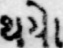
થયો
